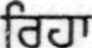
ਰਿਹਾ
